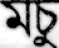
মচু
